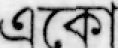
একো
